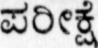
ಪರೀಕ್ಷೆ
